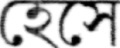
হেসে
